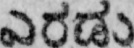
ಎರಡು
